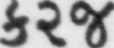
કરજ
